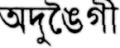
অদুঙৈগী
